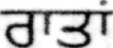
ਰਾਤਾਂ
